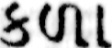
કળા
